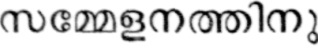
സമ്മേളനത്തിനു
